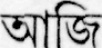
আজি
